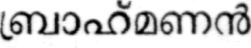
ബ്രാഹ്മണന്‍
